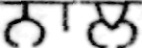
ਨਾਲ
